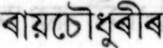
ৰায়চৌধুৰীৰ
